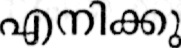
എനിക്കു
